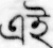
এই
